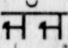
ਜੱਜ
